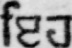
ਇਹ
